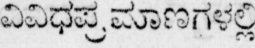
ವಿವಿಧಪ್ರಮಾಣಗಳಲ್ಲಿ
